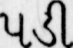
પડી
